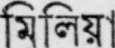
মিলিয়া
